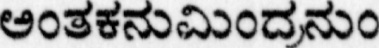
ಅಂತಕನುಮಿಂದ್ರನುಂ
